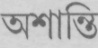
অশান্তি
